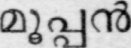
മൂപ്പന്‍
